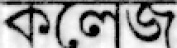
কলেজ
